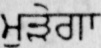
ਮੁੜੇਗਾ
